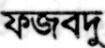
ফজবদু
